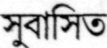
সুবাসিত
